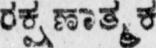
ರಕ್ಷಣಾತ್ಮಕ
